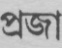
প্ৰজা
